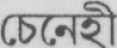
চেনেহী
